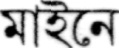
মাইনে
